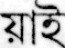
য়াই
